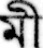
মী
